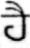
ਹੈ
